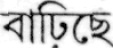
বাঢ়িছে
